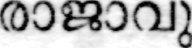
രാജാവു
